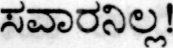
ಸವಾರನಿಲ್ಲ!
